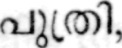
പുത്രി,
